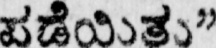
ಪಡೆಯಿತು”
